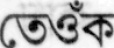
তেওঁক
